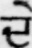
ਦੇ
